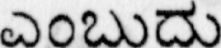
ಎಂಬುದು
